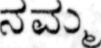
ನಮ್ಮ
